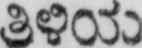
ತಿಳಿಯ
